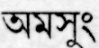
অমসুং
